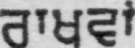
ਰਾਖਵਾਂ
